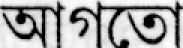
আগতো
